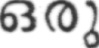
ഒരു
